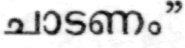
ചാടണം”
